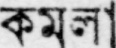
কমলা
